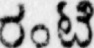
ರಂಟೆ
